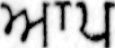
ਆਪ
